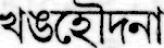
খঙহৌদনা
